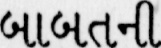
બાબતની
